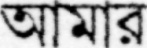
আমার
